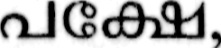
പക്ഷേ,
